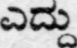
ಎದ್ದು
